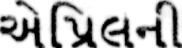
એપ્રિલની
